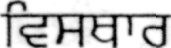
ਵਿਸਥਾਰ
